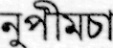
নুপীমচা
